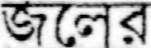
জলের
